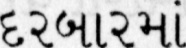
દરબારમાં
